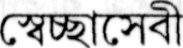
স্বেচ্ছাসেবী
